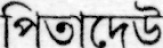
পিতাদেউ
